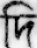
দি
